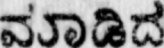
ಮಾಡಿದ
